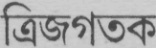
ত্ৰিজগতক
